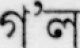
গ'ল
